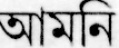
আমনি
